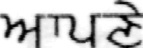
ਆਪਣੇ
